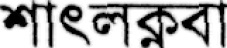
শাৎলক্নবা
